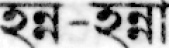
হন্ন-হন্না
